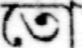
তো
